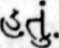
હતું.
